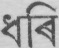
ধৰি
